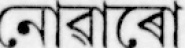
নোৱাৰো
